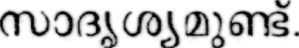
സാദൃശ്യമുണ്ട്.
